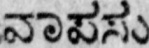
ವಾಪಸು
